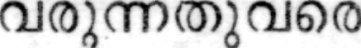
വരുന്നതുവരെ
